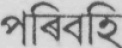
পৰিবহি
